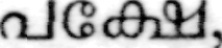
പക്ഷേ,
